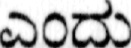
ಎಂದು
